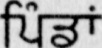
ਪਿੰਡਾਂ
